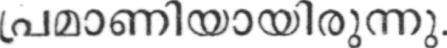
പ്രമാണിയായിരുന്നു.
